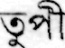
তুপী
